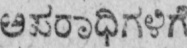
ಅಪರಾಧಿಗಳಿಗೆ
